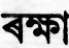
ৰক্ষা
